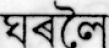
ঘৰলৈ
